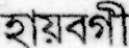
হায়বগী
